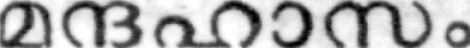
മന്ദഹാസം
